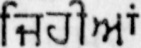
ਜਿਹੀਆਂ
